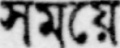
সময়ে
